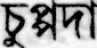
চুপ্পদা
